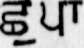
ਛੁਪਾ
